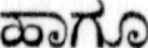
ಹಾಗೂ
